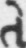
તે
